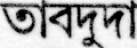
তাবদুদা
